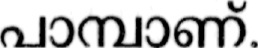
പാമ്പാണ്.
